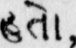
હતો,
